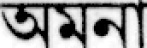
অমনা
